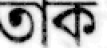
তাক
